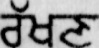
ਰੱਖਣ
